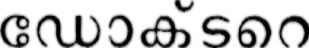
ഡോക്ടറെ
